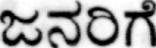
ಜನರಿಗೆ
